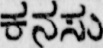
ಕನಸು
